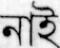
নাই
